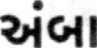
અંબા
